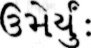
ઉમેર્યું:
